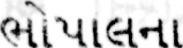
ભોપાલના
